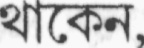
থাকেন,
